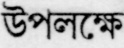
উপলক্ষে
